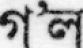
গ'ল
